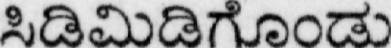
ಸಿಡಿಮಿಡಿಗೊಂಡು
